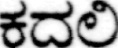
ಕದಲಿ
